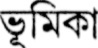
ভূমিকা
